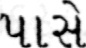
પાસે
